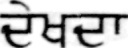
ਦੇਖਦਾ
